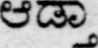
ಆಡ್ತಾ
